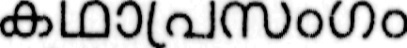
കഥാപ്രസംഗം
